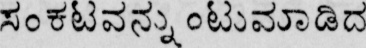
ಸಂಕಟವನ್ನುಂಟುಮಾಡಿದ
